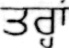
ਤਰ੍ਹਾਂ
